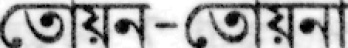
তোয়ন-তোয়না
